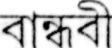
বান্ধবী
